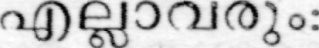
എല്ലാവരും:
